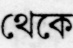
থেকে
